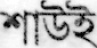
শাউই
